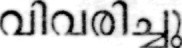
വിവരിച്ചു
